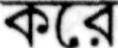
করে
